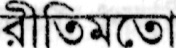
রীতিমতো
